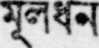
মূলধন
